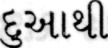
દુઆથી
